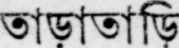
তাড়াতাড়ি
